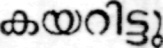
കയറിട്ടു
